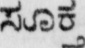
ಸೂಕ್ತ
